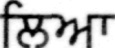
ਲਿਆ
